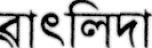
ৱাৎলিদা
